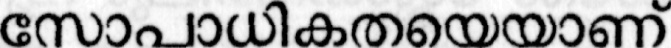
സോപാധികതയെയാണ്
